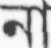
না
